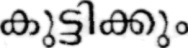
കുട്ടിക്കും
